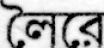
লৈরে
